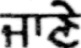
ਜਾਣੇ
